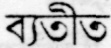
ব্যতীত
